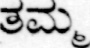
ತಮ್ಮ
